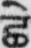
ਛੇ
